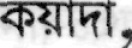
কয়াদা,
